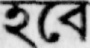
হবে
